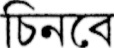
চিনবে
